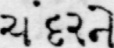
ચંદરને
